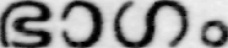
ഭാഗം
